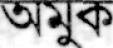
অমুক
